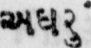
અઘરું
